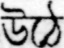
উঠে
